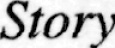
Story
